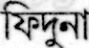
ফিদুনা
